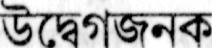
উদ্বেগজনক
